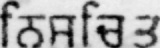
ਨਿਸਚਿਤ
